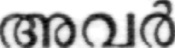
അവര്‍
